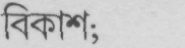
বিকাশ;
